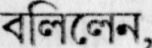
বলিলেন,
